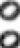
ঃ
